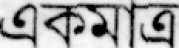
একমাত্র
